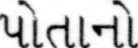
પોતાનો
